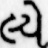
લ્યે
